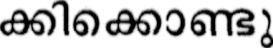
ക്കിക്കൊണ്ടു
